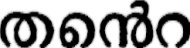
തന്റെ
